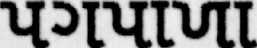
પગપાખા
